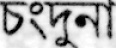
চংদুনা
